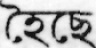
হৈছে
